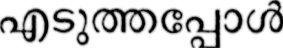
എടുത്തപ്പോള്‍
